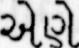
એણે
